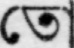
তো
